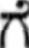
ಗೆ
